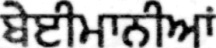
ਬੇਈਮਾਨੀਆਂ
